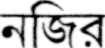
নজির
